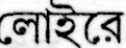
লোইরে
